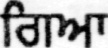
ਗਿਆ
